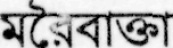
মরৈবাক্তা
